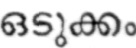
ഒടുക്കം
